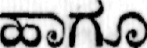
ಹಾಗೂ
